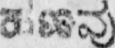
ಹಣವು
